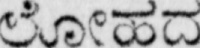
ಲೋಹದ
